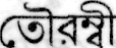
তৌরম্বী
